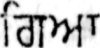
ਗਿਆ
